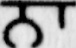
ਨਾ
